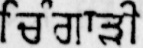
ਚਿੰਗਾੜੀ
